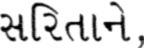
સરિતાને,
